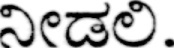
ನೀಡಲಿ.
